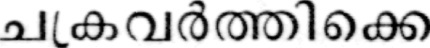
ചക്രവര്‍ത്തിക്കെ
